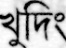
খুদিং
